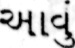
આવું
